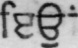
ਇਉਂ
